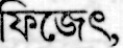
ফিজেৎ,
